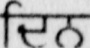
ਦਿਨ
